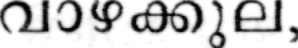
വാഴക്കുല,
